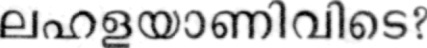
ലഹളയാണിവിടെ?
